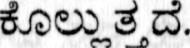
ಕೊಲ್ಲುತ್ತದೆ.
